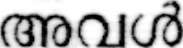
അവള്‍
